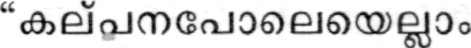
"കല് പനപൊലെയെല്ലാം
